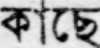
কাছে
